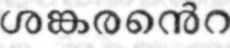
ശങ്കരന്റെ
